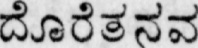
ದೊರೆತನವ
